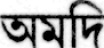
অমদি
